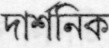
দার্শনিক
